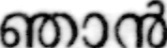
ഞാന്‍
